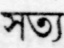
সত্য
